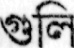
গুলি
